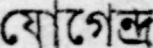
যোগেন্দ্র
